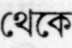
থেকে
